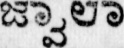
ಜ್ವಾಲಾ
